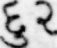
દુર
